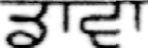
ਡਾਵਾਂ
